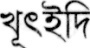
খূৎইদি
